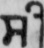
ਸੀ
